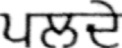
ਪਲਦੇ
